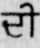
ਦੀ
